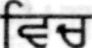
ਵਿਚ
